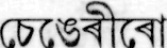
চেঙেৰীৰো
